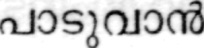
പാടുവാന്‍
